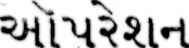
ઑપરેશન
